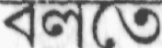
বলতে
